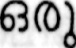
ഒരു
